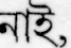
নাই,
